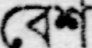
বেশ
